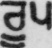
ਰੂਪ
